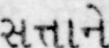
સત્તાને
